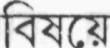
বিষয়ে
